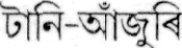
টানি-আঁজুৰি
